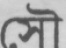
সৌ
